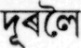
দূৰলৈ
